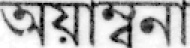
অয়াম্বনা
